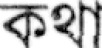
কথা
